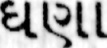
ઘણા
